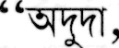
“অদুদা,
